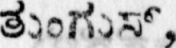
ತುಂಗುಸ್,
